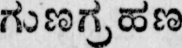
ಗುಣಗ್ರಹಣ
